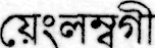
য়েংলম্বগী
